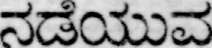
ನಡೆಯುವ
